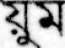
য়ুম
